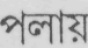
পলায়
